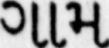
ગામ
